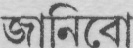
জানিবো
